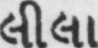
લીલા
